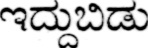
ಇದ್ದುಬಿಡು
